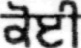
ਕੋਈ
